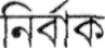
নির্বাক
